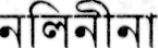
নলিনীনা
